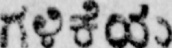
ಗಳಿಕೆಯ
